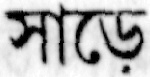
সাড়ে
